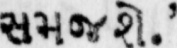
સમજશે.'
